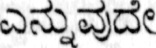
ಎನ್ನುವುದೇ
